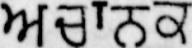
ਅਚਾਨਕ
